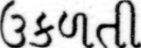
ઉકળતી
